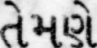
તેમણે
